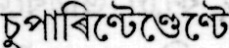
চুপাৰিণ্টেণ্ডেণ্টে
